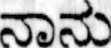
ನಾನು
